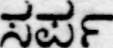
ಸರ್ಪ
